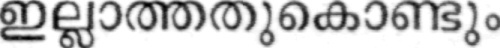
ഇല്ലാത്തതുകൊണ്ടും
